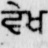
ਵੇਖ
